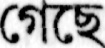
গেছে
